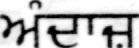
ਅੰਦਾਜ਼
